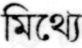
মিথ্যে
